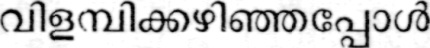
വിളമ്പിക്കഴിഞ്ഞപ്പോള്‍
